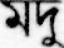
মদু
